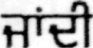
ਜਾਂਦੀ
